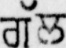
ਗੱਲ
